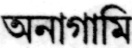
অনাগামি
